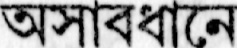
অসাবধানে
